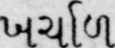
ખર્ચાળ
